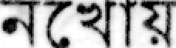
নখোয়
